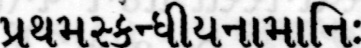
પ્રથમસ્કંન્ધીયાનામાનિઃ
